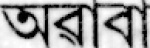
অৱাবা
